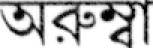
অরুম্বা
